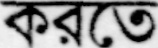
করতে
